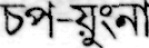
চপ-য়ুংনা
